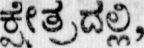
ಕ್ಷೇತ್ರದಲ್ಲಿ,
